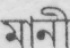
মানী
